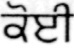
ਕੋਈ
